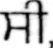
ਸੀ,
